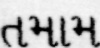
તમામ
